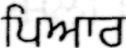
ਪਿਆਰ
